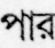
পার
